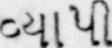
વ્યાપી
